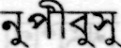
নুপীবুসু
